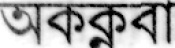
অকক্নবা
